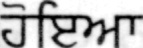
ਹੋਇਆ
